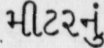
મીટરનું
